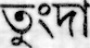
তুংদা
